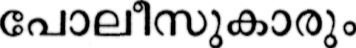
പോലീസുകാരും
